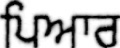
ਪਿਆਰ
